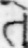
તે
